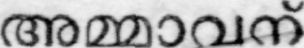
അമ്മാവന്
